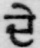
ਦੇ
